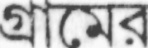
গ্রামের
